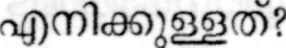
എനിക്കുള്ളത്?
